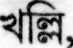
খল্লি,
